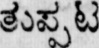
ತುಪ್ಪಟ
